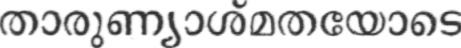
താരുണ്യാശ്മതയോടെ
